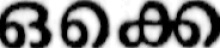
ഒക്കെ
